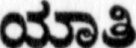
ಯಾತಿ
